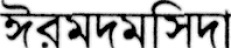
ঈরমদমসিদা
